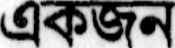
একজন
